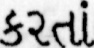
કરતાં
